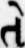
તે
